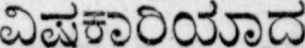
ವಿಷಕಾರಿಯಾದ
